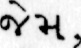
જેમ,
